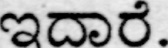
ಇದಾರೆ.
